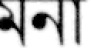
মনা
